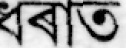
ধৰাত
